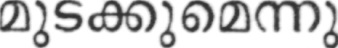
മുടക്കുമെന്നു
